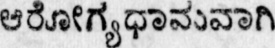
ಆರೋಗ್ಯಧಾಮವಾಗಿ
